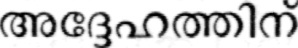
അദ്ദേഹത്തിന്
